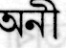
অনী
